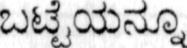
ಬಟ್ಟೆಯನ್ನೂ
